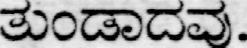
ತುಂಡಾದವು.
